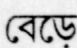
বেড়ে
